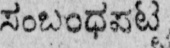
ಸಂಬಂಧಪಟ್ಟ
